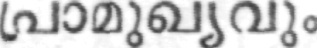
പ്രാമുഖ്യവും
